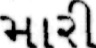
મારી
